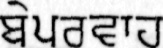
ਬੇਪਰਵਾਹ
